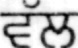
ਵੱਲ
